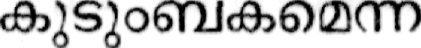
കുടുംബകമെന്ന
